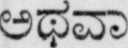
ಅಥವಾ
